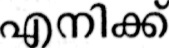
എനിക്ക്
